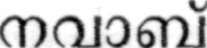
നവാബ്
